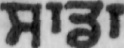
ਸਾਡਾ
